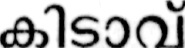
കിടാവ്
